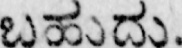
ಬಹುದು.
